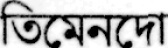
তিমেনদো
